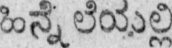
ಹಿನ್ನೆಲೆಯಲ್ಲಿ
